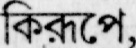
কিরূপে,
